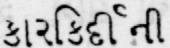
કારકિર્દીની
